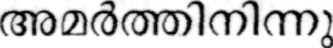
അമര്‍ത്തിനിന്നു
